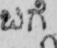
ಬಗ್ಗೆ
